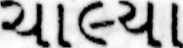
ચાલ્યા
